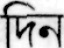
দিন
